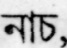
নাচ,
